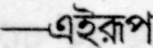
–এইরূপ
